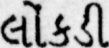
લોંકડી
